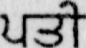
ਪਤੀ
